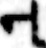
ન
